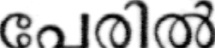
പേരില്‍
